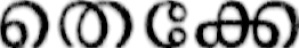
തെക്കേ
